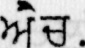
ਐਚ.
